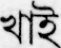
খাই
